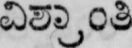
ವಿಶ್ರಾಂತಿ
